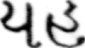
યહ
